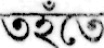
তহঁতে
